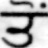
ਤੋਂ
